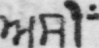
ਅਸੀਂ
